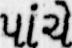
પાંચે
